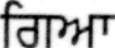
ਗਿਆ
